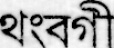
থংবগী
